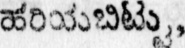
ಹರಿಯಬಿಟ್ಟು,
